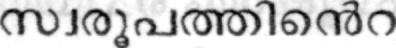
സ്വരൂപത്തിന്റെ
